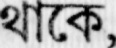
থাকে,
